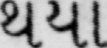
થયા
